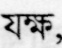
যক্ষ,
